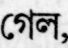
গেল,
